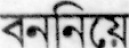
বননিয়ে
